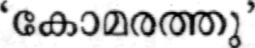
‘കോമരത്തു’
